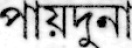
পায়দুনা
